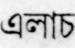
এলাচ
